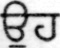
ਉਹ
